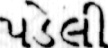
પડેલી
